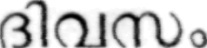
ദിവസം
